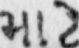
માટે
